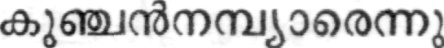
കുഞ്ചന്‍നമ്പ്യാരെന്നു
